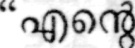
“എന്റെ
